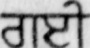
ਗਈ
